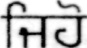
ਜਿਹੋ
